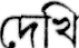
দেখি
